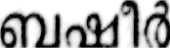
ബഷീര്‍
